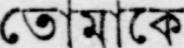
তোমাকে
